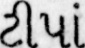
ટીપાં
